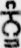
ਨੂੰ
